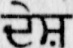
ਦੇਸ਼
